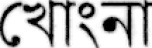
খোংনা
